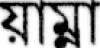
য়াম্না
